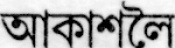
আকাশলৈ
